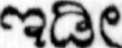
ಇಡೀ
